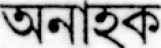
অনাহক
